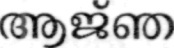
ആജ്ഞ
